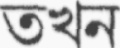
তখন
